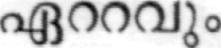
ഏററവും
